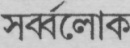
সৰ্ব্বলোক
